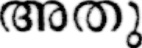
അതു
